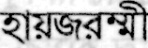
হায়জরম্মী
